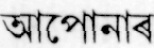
আপোনাৰ
